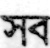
সব
